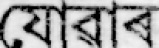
যোৱাৰ
